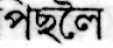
পিছলৈ
